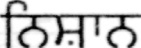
ਨਿਸ਼ਾਨ
